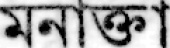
মনাক্তা
